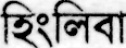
হিংলিবা
